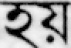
হয়
